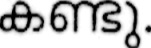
കണ്ടു.
